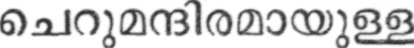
ചെറുമന്ദിരമായുള്ള
